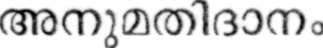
അനുമതിദാനം
